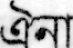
ঐনা
